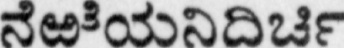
ನೆಱೆಯನಿದಿರ್ಚಿ
